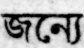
জন্যে
